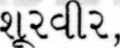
શૂરવીર,
